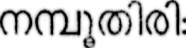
നമ്പൂതിരി:
